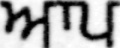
ਆਪ
